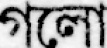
গলো
